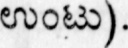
ಉಂಟು).
